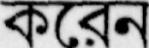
করেন
